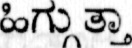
ಹಿಗ್ಗುತ್ತಾ
